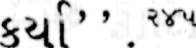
કર્યા".૨૪૫
